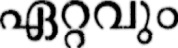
ഏറ്റവും
